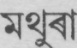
মথুৰা
